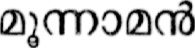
മൂന്നാമന്‍
